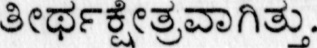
ತೀರ್ಥಕ್ಷೇತ್ರವಾಗಿತ್ತು.
